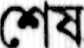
শেষ
